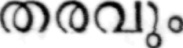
തരവും
